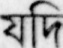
যদি
